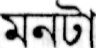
মনটা
